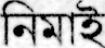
নিমাই
